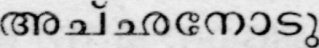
അച്ഛനോടു
